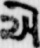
એ
